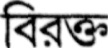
বিরক্ত
